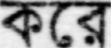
করে
